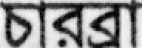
চারব্রা
